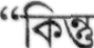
"কিন্তু
